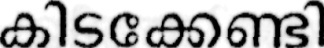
കിടക്കേണ്ടി
